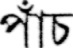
পাঁচ
